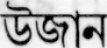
উজান
